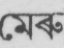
মেৰু
